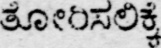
ತೋರಿಸಲಿಕ್ಕೆ
